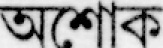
অশোক
